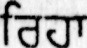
ਰਿਹਾ
